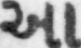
આ
